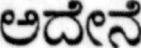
ಅದೇನೆ
